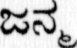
ಜನ್ಮ
